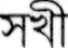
সখী
